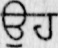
ਉਹ
